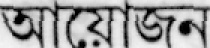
আয়োজন
